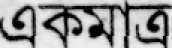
একমাত্র
